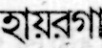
হায়রগা
